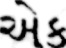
એક
